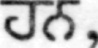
ਹਨ,
